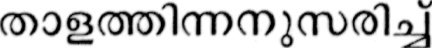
താളത്തിന്നനുസരിച്ച്
